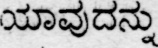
ಯಾವುದನ್ನು
